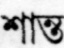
শান্ত
